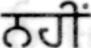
ਨਹੀਂ
